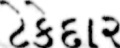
ટેકેદાર
